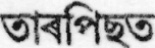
তাৰপিছত
